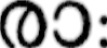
രാ:
